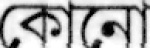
কোনো
